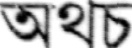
অথচ
